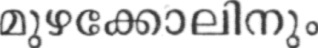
മുഴക്കോലിനും
